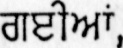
ਗਈਆਂ,
